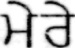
ਮੇਰੇ
